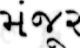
મંજૂર
